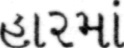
હારમાં
